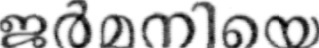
ജര്‍മനിയെ
